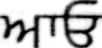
ਆਓ
